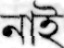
নাই
